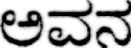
ಅವನ
